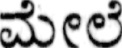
ಮೇಲೆ
